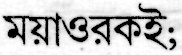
ময়াওরকই;
